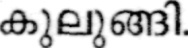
കുലുങ്ങി.
